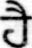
ਹੈ
